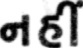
નહીં
